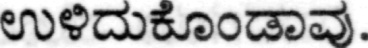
ಉಳಿದುಕೊಂಡಾವು.
